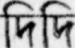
দিদি
